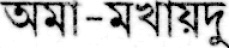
অমা-মখায়দু
